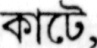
কাটে,
